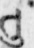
તું
